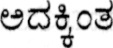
ಅದಕ್ಕಿಂತ
